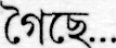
গৈছে...
